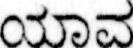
ಯಾವ
